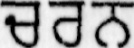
ਚਰਨ
